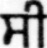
ਸੀ
